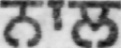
ਨਾਲ
